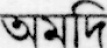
অমদি
